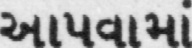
આપવામાં
